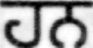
ਹਨ
